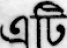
এটি
